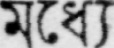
মধ্যে
